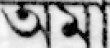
অমা
